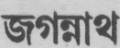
জগন্নাথ
